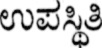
ಉಪಸ್ಥಿತಿ
